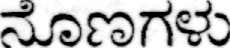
ನೊಣಗಳು
